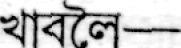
খাবলৈ-
